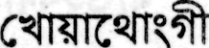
খোয়াথোংগী
